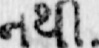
નથી.
